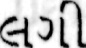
લગી
